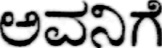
ಅವನಿಗೆ
